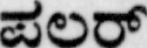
ಪಲರ್
